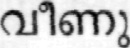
വീണു
